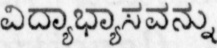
ವಿದ್ಯಾಭ್ಯಾಸವನ್ನು
